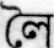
লৈ
